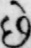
છે
